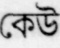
কেউ
